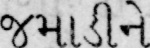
જમાડીને
